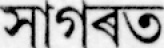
সাগৰত
